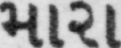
મારા
